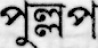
পুল্লপ
